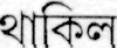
থাকিল
